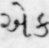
એક
